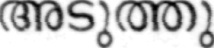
അടുത്തു
